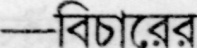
–বিচারের
